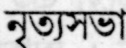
নৃত্যসভা
